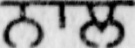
ਨਾਲ
